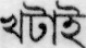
খটাই
